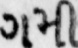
ગમી
